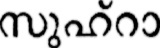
സുഹ്റാ
